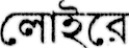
লোইরে
